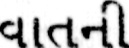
વાતની
